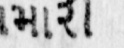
અમારી
